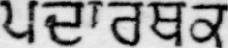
ਪਦਾਰਥਕ
